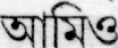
আমিও
